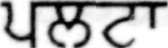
ਪਲਟਾ
